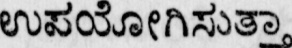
ಉಪಯೋಗಿಸುತ್ತಾ
